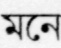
মনে
